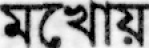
মখোয়
